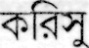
করিসু
